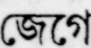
জেগে
